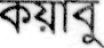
কয়াবু
